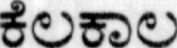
ಕೆಲಕಾಲ
